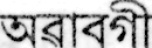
অৱাবগী
